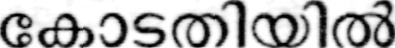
കോടതിയില്‍
